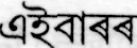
এইবাৰৰ
